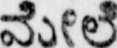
ಮೇಲೆ
